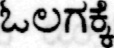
ಓಲಗಕ್ಕೆ
